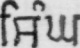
ਸਿੰਘ
